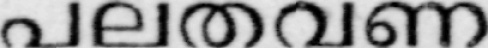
പലതവണ
